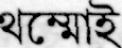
থম্মোই
